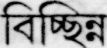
বিচ্ছিন্ন
